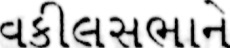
વકીલસભાને
